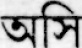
অসি
